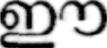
ഈ
